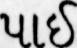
પાઈ
